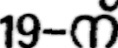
19-ന്
